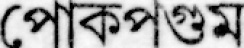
পোকপগুম
